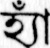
হ্যাঁ
